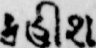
કહીશ
